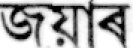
জয়াৰ
